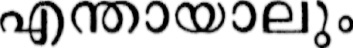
എന്തായാലും
